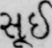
સૂઈ
